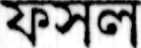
ফসল
